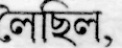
লৈছিল,
